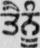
ਤੈਨੂੰ
